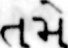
તમે
